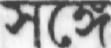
সঙ্গে
